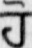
ਹੋ
